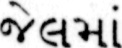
જેલમાં
